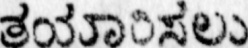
ತಯಾರಿಸಲು
